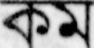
কম
